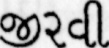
જીરવી
